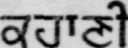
ਕਹਾਣੀ
